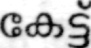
കേട്ട്
